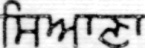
ਸਿਆਣਾ
